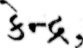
કેન્દ્ર,
